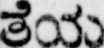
ತೆಯ
